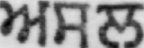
ਅਸਲ
